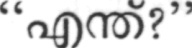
"എന്ത്?"
